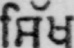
ਸਿੱਖ
